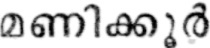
മണിക്കൂര്‍
